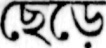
ছেড়ে
